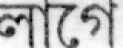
লাগে
